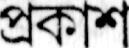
প্রকাশ
